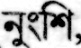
নুংশি,
